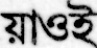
য়াওই
